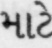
માટે
